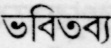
ভবিতব্য
